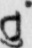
તું
